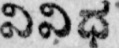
ವಿವಿಧ
